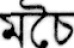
মচৈ
